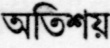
অতিশয়
